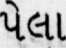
પેલા
